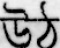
উঠ
